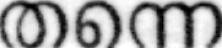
തന്നെ
